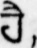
ਹੈ,
